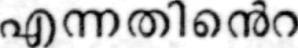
എന്നതിന്റെ
